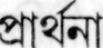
প্রার্থনা
